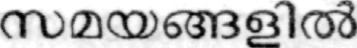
സമയങ്ങളില്‍
